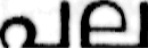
പല
